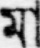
মা
